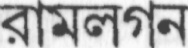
রামলগন
